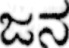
ಜನ
